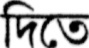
দিতে
